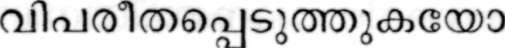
വിപരീതപ്പെടുത്തുകയോ
